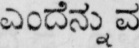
ಎಂದೆನ್ನುವ
